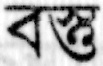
বস্তু
